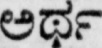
ಅರ್ಥ
